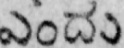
ಎಂದು
